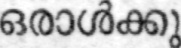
ഒരാള്‍ക്കു
